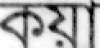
কয়া
